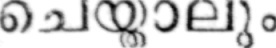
ചെയ്താലും
